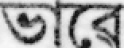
ভাৱে
